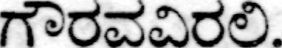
ಗೌರವವಿರಲಿ.
